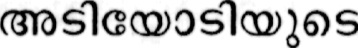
അടിയോടിയുടെ
